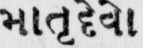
માતૃદેવો
